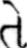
તે
